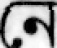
নে
